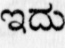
ಇದು
